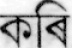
কৰি
